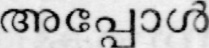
അപ്പോള്‍
